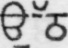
ਉੱਠ
